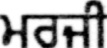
ਮਰਜੀ
